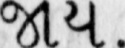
જાય.
